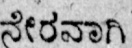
ನೇರವಾಗಿ
